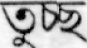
তুচ্ছ
